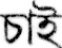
চাই
